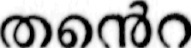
തന്റെ
